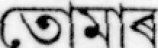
তোমাৰ
